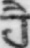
ਹੈ
